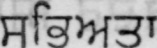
ਸਭਿਅਤਾ
